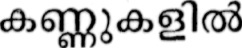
കണ്ണുകളില്‍
